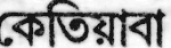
কেতিয়াবা
